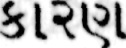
કારણ
